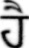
ਹੈ
